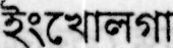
ইংখোলগা
